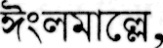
ঈংলমাল্লে,
